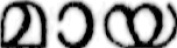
മായ
